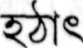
হঠাৎ
